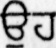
ਉਹ
